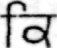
ਕਿ
